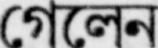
গেলেন
